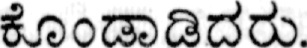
ಕೊಂಡಾಡಿದರು.
